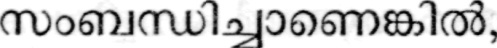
സംബന്ധിച്ചാണെങ്കില്‍,
